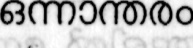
ഒന്നാന്തരം
